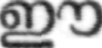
ഈ
